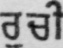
ਰੁਚੀ
